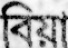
বিয়া
